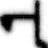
ન
